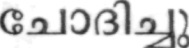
ചോദിച്ചു
